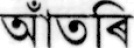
আঁতৰি
